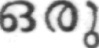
ഒരു
